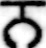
ਨ
